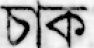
চাক
